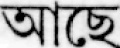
আছে
